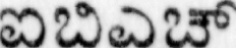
ಐಬಿಎಚ್
